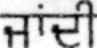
ਜਾਂਦੀ
